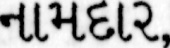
નામદાર,
